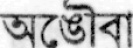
অঙৌবা
